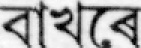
বাখৰে
